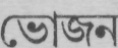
ভোজন
